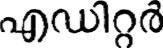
എഡിറ്റര്‍
